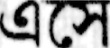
এসে
